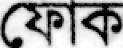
ফোক
